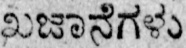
ಖಜಾನೆಗಳು
